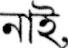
নাই,
